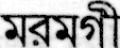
মরমগী
